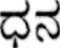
ಧನ
